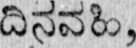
ದಿನವಹಿ,
